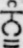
ਨੂੰ
